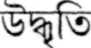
উদ্ধৃতি
